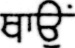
ਥਾਉਂ
